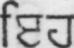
ਇਹ
